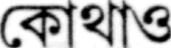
কোথাও
